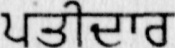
ਪਤੀਦਾਰ
